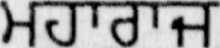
ਮਹਾਰਾਜ
